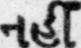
નહીં
